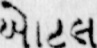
બોટલ
